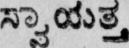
ಸ್ವಾಯತ್ತ
